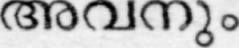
അവനും
